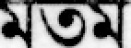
মতম
